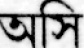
অসি
